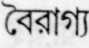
বৈরাগ্য
